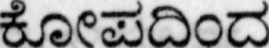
ಕೋಪದಿಂದ
